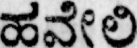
ಹವೇಲಿ
